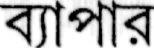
ব্যাপার
